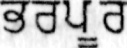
ਭਰਪੂਰ
